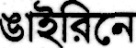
ঙাইরিনে
